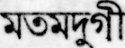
মতমদুগী
